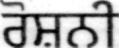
ਰੋਸ਼ਨੀ
